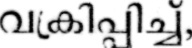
വക്രിപ്പിച്ച്,
